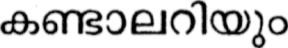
കണ്ടാലറിയും
